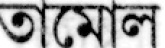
তামোল
